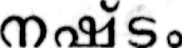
നഷ്ടം
